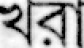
খরা
